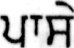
ਪਾਸੇ
